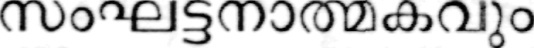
സംഘട്ടനാത്മകവും
